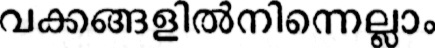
വക്കങ്ങളില്‍നിന്നെല്ലാം
